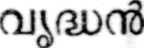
വൃദ്ധന്‍
